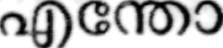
എന്തോ
